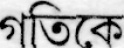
গতিকে
